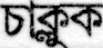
চাক্লুক
